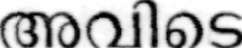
അവിടെ
